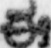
ಈ
